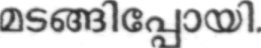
മടങ്ങിപ്പോയി.
